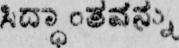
ಸಿದ್ಧಾಂತವನ್ನು
